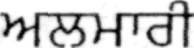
ਅਲਮਾਰੀ
